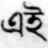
এই
